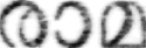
രാമ
